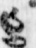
હું
